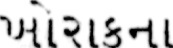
ખોરાકના
